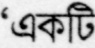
‘একটি
